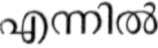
എന്നില്‍
